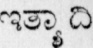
ಇತ್ಯಾದಿ
